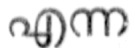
എന്ന
